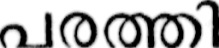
പരത്തി
